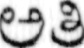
ಅತಿ
